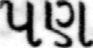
પણ
